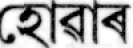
হোৱাৰ
